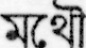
মথৌ
